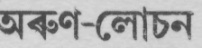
অৰুণ-লোচন
